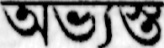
অভ্যস্ত
